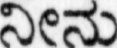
ನೀನು
